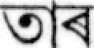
তাৰ
